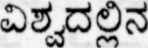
ವಿಶ್ವದಲ್ಲಿನ
